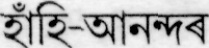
হাঁহি-আনন্দৰ
